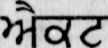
ਐਕਟ
